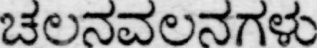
ಚಲನವಲನಗಳು
